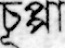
চূপ্পা
